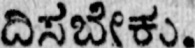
ದಿಸಬೇಕು.
